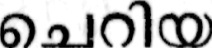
ചെറിയ
